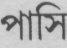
পাসি
